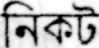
নিকট
